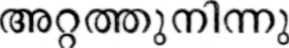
അറ്റത്തുനിന്നു
